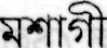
মশাগী
